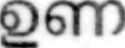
ഉണ
